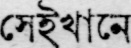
সেইখানে
